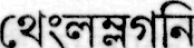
থেংলম্লগনি
